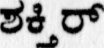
ಶಕ್ತಿರ್
